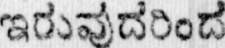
ಇರುವುದರಿಂದ
